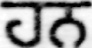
ਹਨ
